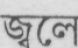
জ্বলে
